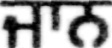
ਜਾਨ
